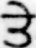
ਤੇ
